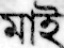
মাই
